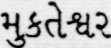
મુક્તેશ્વર
